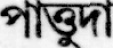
পাত্তুদা
